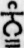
ਨੂੰ
